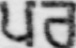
ਪਰ
